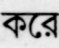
করে
